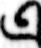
এ
